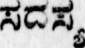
ಸದಸ್ಯ
